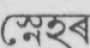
স্নেহৰ
